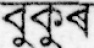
বুকুৰ
